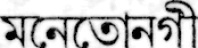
মনেতোনগী
